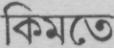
কিমতে
